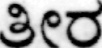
ತೀರ
